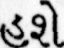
હશે
